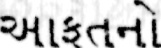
આફતનો
